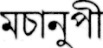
মচানুপী
